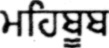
ਮਹਿਬੂਬ
